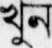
খুন
